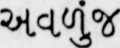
અવળુંજ
